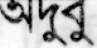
অদুবু
